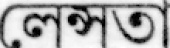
লেন্সতা
